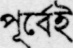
পূর্বেই
